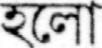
হলো
